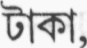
টাকা,
